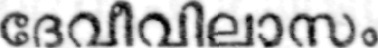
ദേവീവിലാസം
